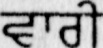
ਵਾਰੀ
